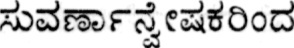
ಸುವರ್ಣಾನ್ವೇಷಕರಿಂದ
